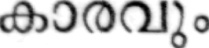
കാരവും
